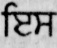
ਇਸ
